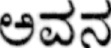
ಅವನ
